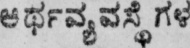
ಅರ್ಥವ್ಯವಸ್ಥೆಗಳ
